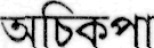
অচিকপা
